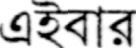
এইবার
